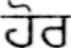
ਹੋਰ
